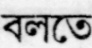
বলতে
